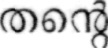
തന്റെ
